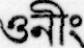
ওনীং
